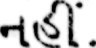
નહીં.
